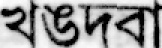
খঙদবা
